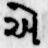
એ
